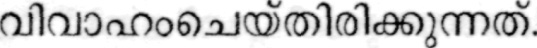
വിവാഹംചെയ്തിരിക്കുന്നത്.
